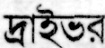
দ্রাইভর
